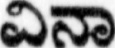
ವಿನಾ
